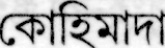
কোহিমাদা
